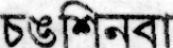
চঙশিনবা
